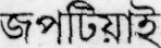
জপটিয়াই
